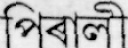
পিৰালী
